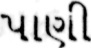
પાણી
